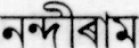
নন্দীৰাম
